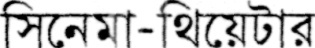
সিনেমা-থিয়েটার
